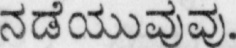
ನಡೆಯುವುವು.
